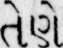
તેણે
